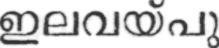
ഇലവയ്പു
